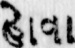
હોવા
